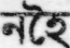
নহৈ
